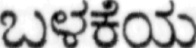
ಬಳಕೆಯ
